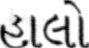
હાલો
